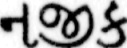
નજીક
